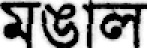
মঙাল
